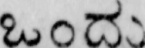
ಒಂದು
